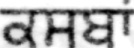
ਕਸਬਾਂ
